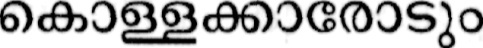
കൊള്ളക്കാരോടും
